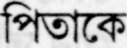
পিতাকে
